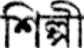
শিল্পী
